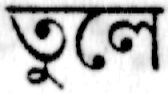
তুলে
